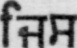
ਜਿਸ
